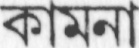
কামনা
